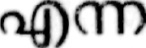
എന്ന
